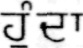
ਹੁੰਦਾ
